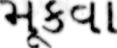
મૂકવા
